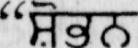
''ਸ਼ੋਭਨ
